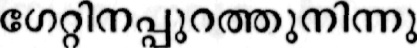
ഗേറ്റിനപ്പുറത്തുനിന്നു
